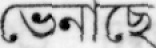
ভেনাছে
